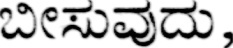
ಬೀಸುವುದು,
